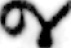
જ
